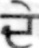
ਦੇ
